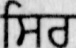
ਸਿਰ
